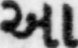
આ
